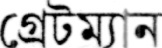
গ্রেটম্যান
